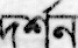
দর্শন
